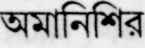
অমানিশির
